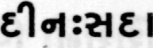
દીનઃસદા
